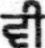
ਵੀ
